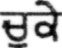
ਚੁਕੇ
